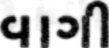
વાગી
